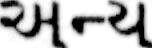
અન્ય
